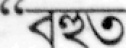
"বহুত
